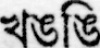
খঙঙি
